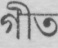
গীত
